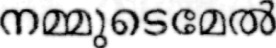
നമ്മുടെമേല്‍
